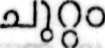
ചുറ്റം
